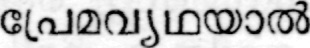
പ്രേമവ്യഥയാല്‍
